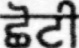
ਛੋਟੀ
